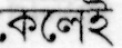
কেলেই
